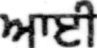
ਆਈ
